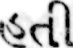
હતી
